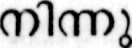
നിന്നു
